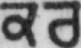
ਕਰ
